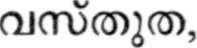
വസ്തുത,
